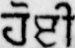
ਹੋਈ
